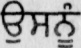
ਉਸਨੂੰ
